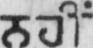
ਨਹੀਂ
